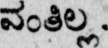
ವಂತಿಲ್ಲ.
